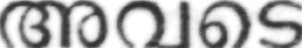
അവടെ
